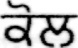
ਕੋਲ
